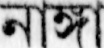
নাঙ্গা
